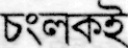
চংলকই
